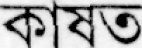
কাষত
